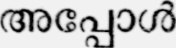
അപ്പോള്‍
